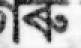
গৰু
